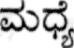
ಮಧ್ಯೆ
